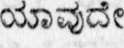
ಯಾವುದೇ
